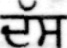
ਦੱਸ
